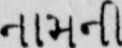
નામની
